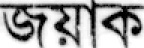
জয়াক
